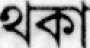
থকা
